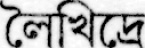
লৈখিদ্রে
